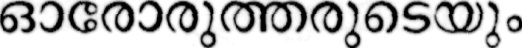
ഓരോരുത്തരുടെയും
